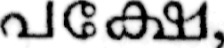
പക്ഷേ,
